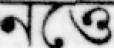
নত্তে
